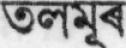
তলমূৰ
